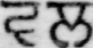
ਵਲ
